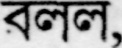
বলল,
